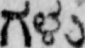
ಗಳು
